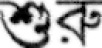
শুরু
